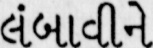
લંબાવીને
